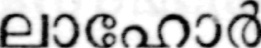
ലാഹോര്‍
